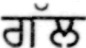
ਗੱਲ
